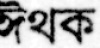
ঈথক
